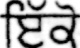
ਇੱਕੋ
